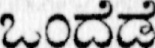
ಒಂದೆಡೆ
